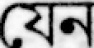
যেন
